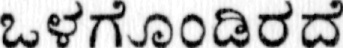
ಒಳಗೊಂಡಿರದೆ
